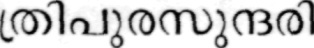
ത്രിപുരസുന്ദരി
